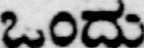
ಒಂದು
